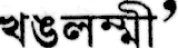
খঙলম্মী’
